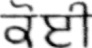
ਕੋਈ
